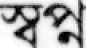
স্বপ্ন
